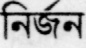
নির্জন
